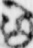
છે
